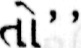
તો"
